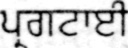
ਪ੍ਰਗਟਾਈ
